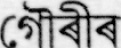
গৌৰীৰ
